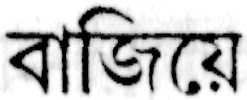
বাজিয়ে
